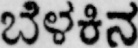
ಬೆಳಕಿನ
